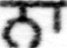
ਨਾ
